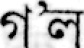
গ'ল
